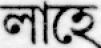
লাহে
